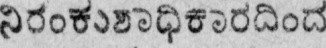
ನಿರಂಕುಶಾಧಿಕಾರದಿಂದ
